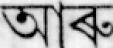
আৰু
